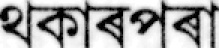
থকাৰপৰা
